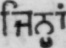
ਜਿਨ੍ਹਾਂ
